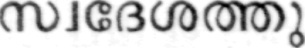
സ്വദേശത്തു
